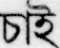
চাই
